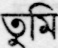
তুমি
